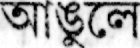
আঙুলে
